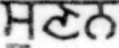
ਸੁਣਨ
